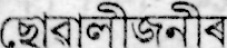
ছোৱালীজনীৰ
